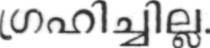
ഗ്രഹിച്ചില്ല.
